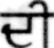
ਦੀ
